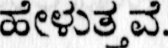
ಹೇಳುತ್ತವೆ.
